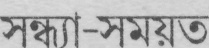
সন্ধ্যা-সময়ত
